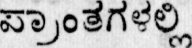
ಪ್ರಾಂತಗಳಲ್ಲಿ
